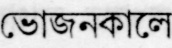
ভোজনকালে
